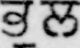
ਭੁਲ
